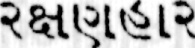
રક્ષણહાર
